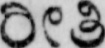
ರೀತಿ
